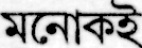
মনোকই
